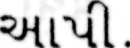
આપી.
